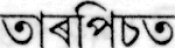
তাৰপিচত
